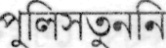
পুলিসতুননি
